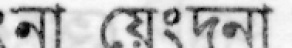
খোয়শাওননা
